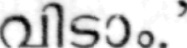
വിടാം.'
